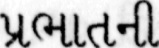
પ્રભાતની
